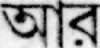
আর
